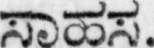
ಸಾಹಸ.
